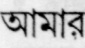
আমার
